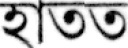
হাতত
